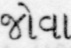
જોવા
